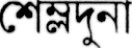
শেম্লদুনা
